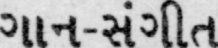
ગાન-સંગીત
